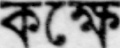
কক্ষে
